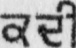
ਕਦੀ
